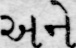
અને
